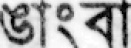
ঙাংবা
